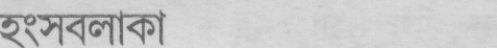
হংসবলাকা
